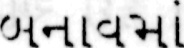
બનાવમાં
